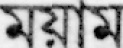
ময়াম
